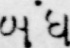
ખંઘ
